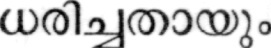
ധരിച്ചതായും
